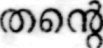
തന്റെ
